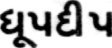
ધૂપદીપ
